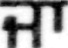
ਜਾ
